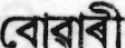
বোৱাৰী
